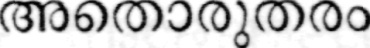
അതൊരുതരം
